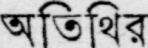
অতিথির
